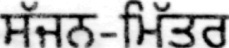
ਸੱਜਨ-ਮਿੱਤਰ
